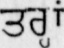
ਤਰ੍ਹਾਂ
